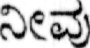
ನೀವು
